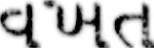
વખત
